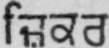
ਜ਼ਿਕਰ
